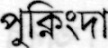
পুক্নিংদা
